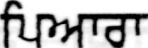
ਪਿਆਰਾ
